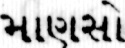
માણસો
